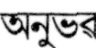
অনুভৱ
